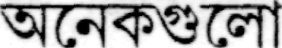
অনেকগুলো
